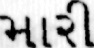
મારી
